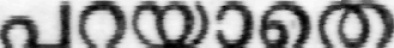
പറയാതെ
